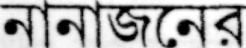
নানাজনের
